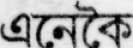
এনেকৈ
